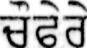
ਚੌਫੇਰੇ
